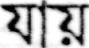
যায়
